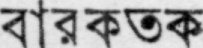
বারকতক
